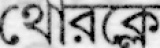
থোরক্লে
